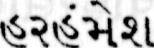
હરહંમેશ
